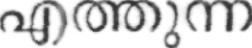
എത്തുന്ന
